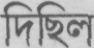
দিছিল
